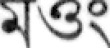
মওং
